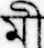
মী
